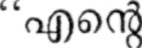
"എന്റെ
